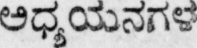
ಅಧ್ಯಯನಗಳ
